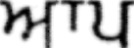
ਆਪ
